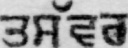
ਤਸੱਵਰ
